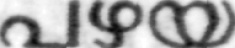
പഴയ
